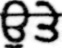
ਉਤੇ
